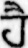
ਹੈ
